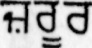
ਜ਼ਰੂਰ
